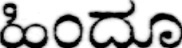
ಹಿಂದೂ
